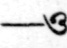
–ও
